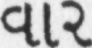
વાર
